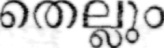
തെല്ലും
